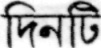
দিনটি
